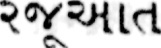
રજૂઆત
